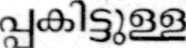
പ്പകിട്ടുള്ള
